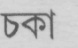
চকা
